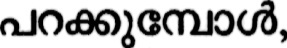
പറക്കുമ്പോള്‍,
